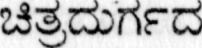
ಚಿತ್ರದುರ್ಗದ
